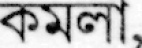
কমলা,
